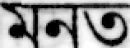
মনত
